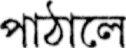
পাঠালে
